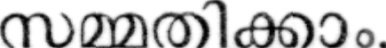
സമ്മതിക്കാം.
